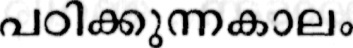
പഠിക്കുന്നകാലം
